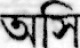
অসি
